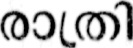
രാത്രി
